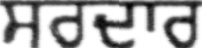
ਸਰਦਾਰ
